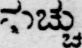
ನುಚ್ಚು
